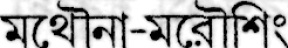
মথৌনা-মরৌশিং
